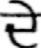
ਦੇ
